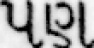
પણ
